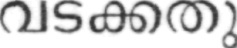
വടക്കതു
